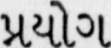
પ્રયોગ
